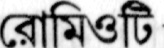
রোমিওটি
